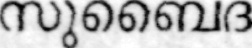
സുബൈദ
